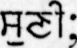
ਸੁਣੀ;
